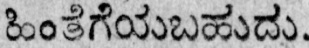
ಹಿಂತೆಗೆಯಬಹುದು.
